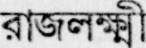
রাজলক্ষ্মী
